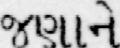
જણાને
